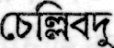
চেল্লিবদু
